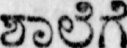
ಶಾಲೆಗೆ
